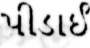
પીડાઈ
